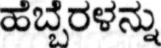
ಹೆಬ್ಬೆರಳನ್ನು
